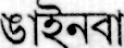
ঙাইনবা
